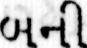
બની
